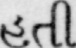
હતી
